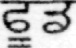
ਫੂਡ
